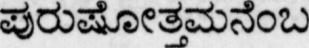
ಪುರುಷೋತ್ತಮನೆಂಬ
